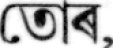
তোৰ,
